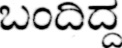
ಬಂದಿದ್ದ
